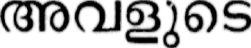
അവളുടെ
